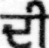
ਦੀ
